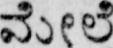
ಮೇಲೆ
